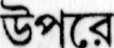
উপরে
